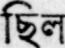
ছিল
